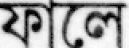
ফালে
